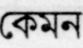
কেমন
